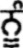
ਨੂੰ
